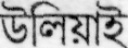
উলিয়াই
